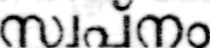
സ്വപ്നം
